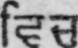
ਵਿਚ
